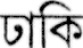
ঢাকি
